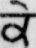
ਕੇ
